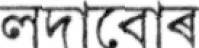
লদাবোৰ
